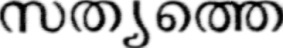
സത്യത്തെ
